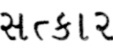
સત્કાર
